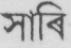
সাৰি
